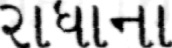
રાધાના
